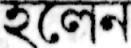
হলেন
